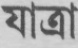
যাত্ৰা
